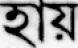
হায়
